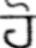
ਹੋ
